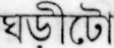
ঘড়ীটো
